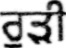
ਰੁੜੀ
